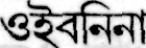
ওইবনিনা
